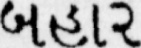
બહાર
